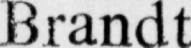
Brandt
